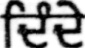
ਦਿੰਦੇ
